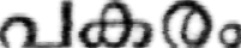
പകരം
